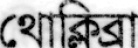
থোক্লিব্রা
